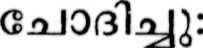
ചോദിച്ചു:
